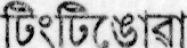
টিংটিঙোৱা
